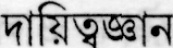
দায়িত্বজ্ঞান
